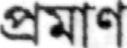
প্রমাণ
